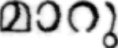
മാറു
